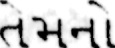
તેમનો
